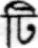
টি
